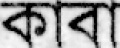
কাবা
